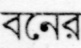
বনের
